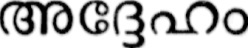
അദ്ദേഹം
